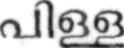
പിള്ള
